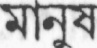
মানুষ
